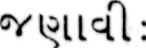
જણાવીઃ
